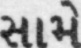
સામે
